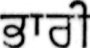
ਭਾਰੀ
